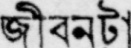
জীবনটা
